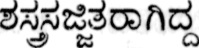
ಶಸ್ತ್ರಸಜ್ಜಿತರಾಗಿದ್ದ
